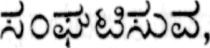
ಸಂಘಟಿಸುವ,
